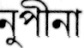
নুপীনা
